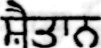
ਸ਼ੈਤਾਨ
